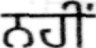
ਨਹੀਂ
